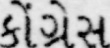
કોંગ્રેસ
